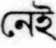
নেই
